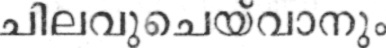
ചിലവുചെയ്വാനും
